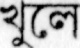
খুলে
